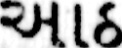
આઠ
